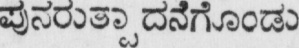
ಪುನರುತ್ಪಾದನೆಗೊಂಡು
